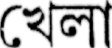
খেলা
